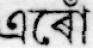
এৰোঁ
